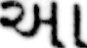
આ
